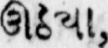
ઊઠ્યા,
